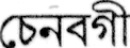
চেনবগী
